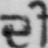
ਦੀ
